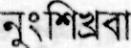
নুংশিখ্রবা
